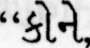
"કોને,
